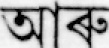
আৰু
